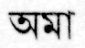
অমা
